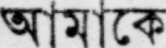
আমাকে
